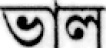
ভাল
